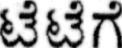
ಟೆಟೆಗೆ
